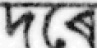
দৰে
